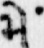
મેં
